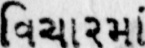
વિચારમાં
